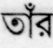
তাঁর
